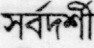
সর্বদর্শী
